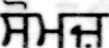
ਸੋਮਜ਼
